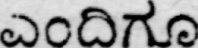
ಎಂದಿಗೂ
